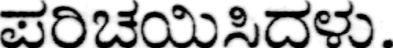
ಪರಿಚಯಿಸಿದಳು.
